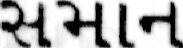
સમાન
